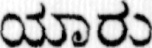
ಯಾರು
